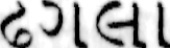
ઢગલા
